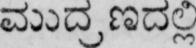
ಮುದ್ರಣದಲ್ಲಿ
